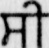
ਸੀ
